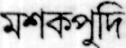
মশকপুদি
